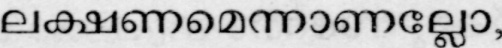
ലക്ഷണമെന്നാണല്ലോ,
